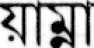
য়াম্না
